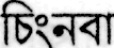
চিংনবা
